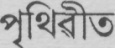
পৃথিৱীত
